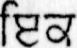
ਇਕ
